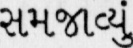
સમજાવ્યું
